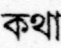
কথা
